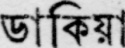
ডাকিয়া
